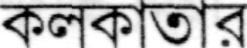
কলকাতার
